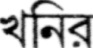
খনির
